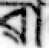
ৱা
